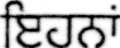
ਇਹਨਾਂ
